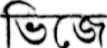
ভিজে
